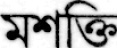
মশক্তি
